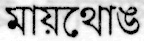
মায়থোঙ
